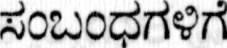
ಸಂಬಂಧಗಳಿಗೆ
